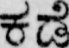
ಕಡೆ
